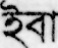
ইবা
